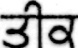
ਤੀਕ
